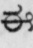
ಈ
